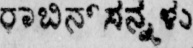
ರಾಬಿನ್ ಸನ್ನಳು
